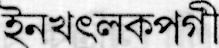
ইনখৎলকপগী
